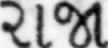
રાજા
